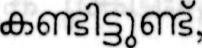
കണ്ടിട്ടുണ്ട്,
